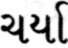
ચર્યા
